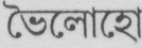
ভৈলোহো
